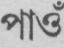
পাওঁ
